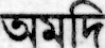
অমদি
